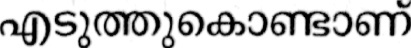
എടുത്തുകൊണ്ടാണ്
